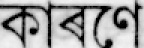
কাৰণে
